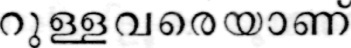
റുള്ളവരെയാണ്
